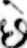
છે
